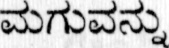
ಮಗುವನ್ನು
